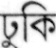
ঢুকি
